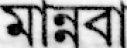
মান্নবা
